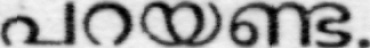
പറയണ്ട.
